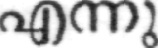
എന്നു
